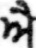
ਐ
